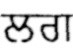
ਲਗ
